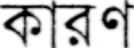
কারণ
